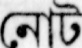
নোট
